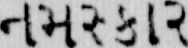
નમસ્કાર
